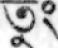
তুং
